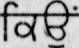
ਕਿਉਂ
